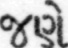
જણે
